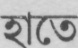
হাতে
